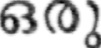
ഒരു
